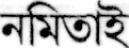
নমিতাই
